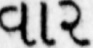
વાર
